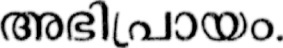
അഭിപ്രായം.
